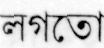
লগতো
